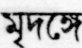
মৃদঙ্গে
